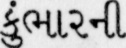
કુંભારની
